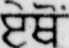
ਏਥੋਂ
